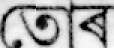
তোৰ
